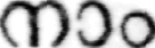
നാം
